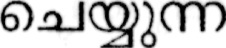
ചെയ്യുന്ന
